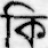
কি
